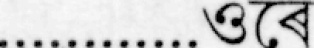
............ওৰে
